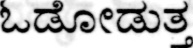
ಓಡೋಡುತ್ತ
